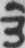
ਤੇ
